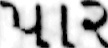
પાર
